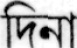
দিনা
